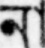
না
